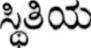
ಸ್ಥಿತಿಯ
